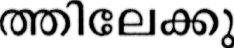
ത്തിലേക്കു
